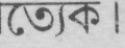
প্ৰত্যেক
